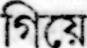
গিয়ে
